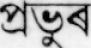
প্রভুৰ
